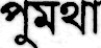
পুমথা
